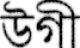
উগী
